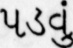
પડવું
